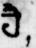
ਹੈ,
